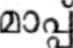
മാപ്പ്
